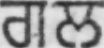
ਗਲ
